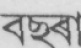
বছৰা
